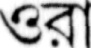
ওরা
